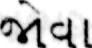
જોવા
